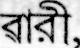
ৱারী,
